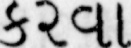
કરવા
